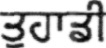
ਤੁਹਾਡੀ
